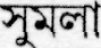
সুমলা
